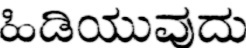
ಹಿಡಿಯುವುದು
